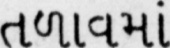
તળાવમાં
